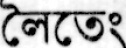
লৈতেং
